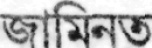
জামিনত
